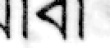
য়াবা
